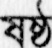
ষষ্ঠ
